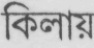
কিলায়
